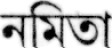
নমিতা
